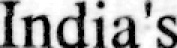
India's
